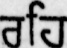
ਰਹਿ
